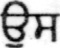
ਉਸ
